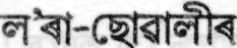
ল'ৰা-ছেৱালীৰ
